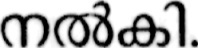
നല്‍കി.
